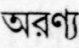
অরণ্য
